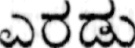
ಎರಡು
